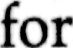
for
